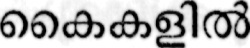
കൈകളില്‍
